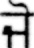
ਜੋ
